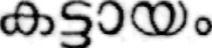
കട്ടായം
